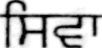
ਸਿਵਾ
